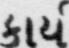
કાર્ય
